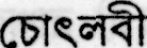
চোৎলবী
